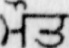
ਮੌਤ
